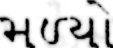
મળ્યો
